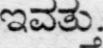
ಇವತ್ತು.
